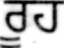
ਰੂਹ
